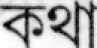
কথা
